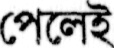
পেলেই
